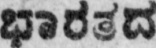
ಭಾರತದ
